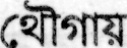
থৌগায়
